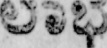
ಲಾಭ
